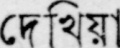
দেখিয়া
